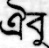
ঐবু
